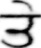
ਤੇ
